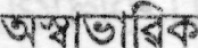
অস্বাভাৱিক
